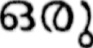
ഒരു
